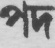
পদ
